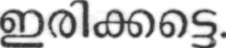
ഇരിക്കട്ടെ.
